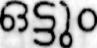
ഒട്ടും
